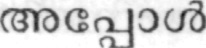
അപ്പോള്‍
